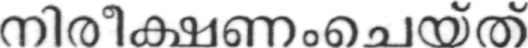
നിരീക്ഷണംചെയ്ത്
